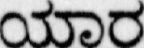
ಯಾರ
